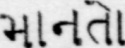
માનતો
